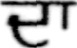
ਦਾ
